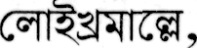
লোইখ্রমাল্লে,
